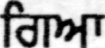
ਗਿਆ
